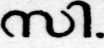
സി.
